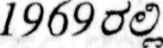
1969ರಲ್ಲಿ
